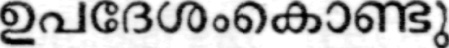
ഉപദേശംകൊണ്ടു
